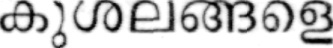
കുശലങ്ങളെ
